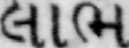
લાભ
